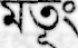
মতূং
